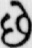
છે
